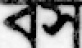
বস
